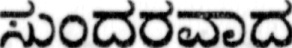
ಸುಂದರವಾದ
